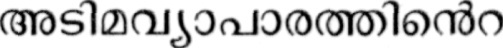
അടിമവ്യാപാരത്തിന്റെ
